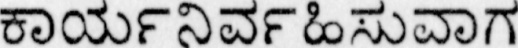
ಕಾರ್ಯನಿರ್ವಹಿಸುವಾಗ
